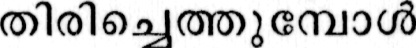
തിരിച്ചെത്തുമ്പോള്‍
